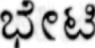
ಭೇಟಿ
